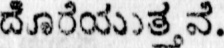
ದೊರೆಯುತ್ತವೆ.
